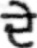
ਦੇ
